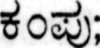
ಕಂಪು;
